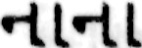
નાના
